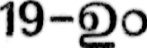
19-ഉം
